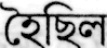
হৈছিল
